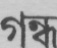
গন্ধ
